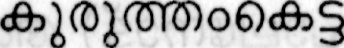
കുരുത്തംകെട്ട
